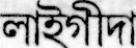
লাইগীদা
